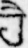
ਹੈ
